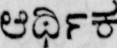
ಆರ್ಥಿಕ
